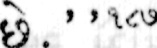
છે."૧૮૭
